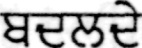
ਬਦਲਦੇ
